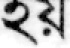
হয়
